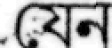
যেন
